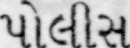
પોલીસ
